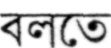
বলতে
